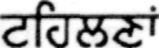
ਟਹਿਲਣਾਂ
